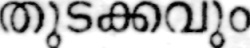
തുടക്കവും
